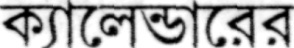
ক্যালেন্ডারের
